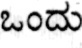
ಒಂದು
